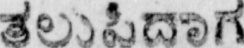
ತಲುಪಿದಾಗ
